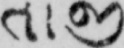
તાજી
